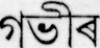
গভীৰ
